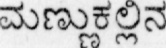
ಮಣ್ಣುಕಲ್ಲಿನ
